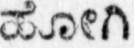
ಹೋಗಿ
